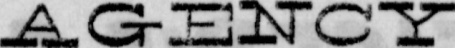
AGENCY
